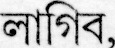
লাগিব,
